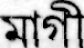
মাগী
